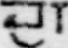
ਦਾ
